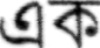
এক
